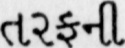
તકફની
